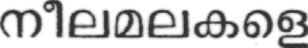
നീലമലകളെ
